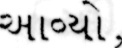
આવ્યો,
